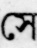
সে
